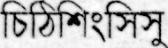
চিঠিশিংসিসু
